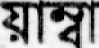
য়াম্বা
